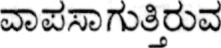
ವಾಪಸಾಗುತ್ತಿರುವ
